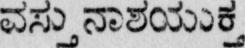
ವಸ್ತುನಾಶಯುಕ್ತ
